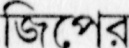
জিপের
